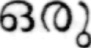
ഒരു
